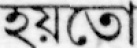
হয়তো
